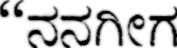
"ನನಗೀಗ
